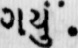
ગયું.
